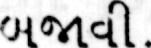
બજાવી.
